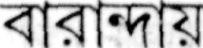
বারান্দায়
